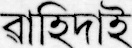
ৱাহিদাই
